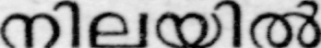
നിലയില്‍
